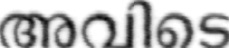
അവിടെ
